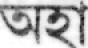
অহা
